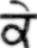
ਕੇ
